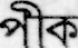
পীক
